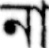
না
